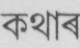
কথাৰ
